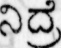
ನಿದ್ರೆ
